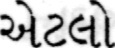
એટલો
